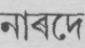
নাৰদে
